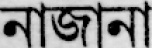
নাজানা
